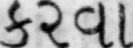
કરવા
